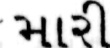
મારી
